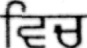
ਵਿਚ
